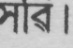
সৱি।
